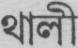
থালী
